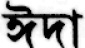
ঈদা
